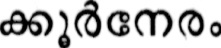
ക്കൂര്‍നേരം
